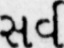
સર્વ
